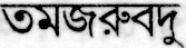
তমজরুবদু
